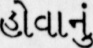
હોવાનું
